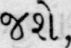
જશે,
